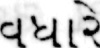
વધારે
